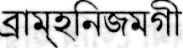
ব্রামহনিজমগী
